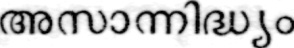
അസാന്നിദ്ധ്യം
